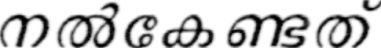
നല്‍കേണ്ടത്
